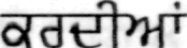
ਕਰਦੀਆਂ
